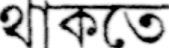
থাকতে
